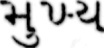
મુખ્ય
